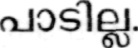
പാടില്ല.
